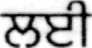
ਲਈ
